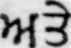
ਅਤੇ
